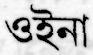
ওইনা
